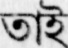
তাই
